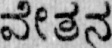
ವೇತನ
